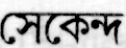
সেকেন্দ
